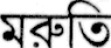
মরুতি
